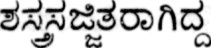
ಶಸ್ತ್ರಸಜ್ಜಿತರಾಗಿದ್ದ
